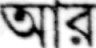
আর
